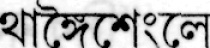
থাঙ্গৈশেংলে
